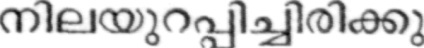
നിലയുറപ്പിച്ചിരിക്കു
